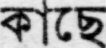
কাছে
